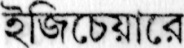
ইজিচেয়ারে
